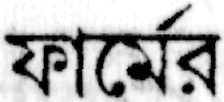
ফার্মের
